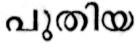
പുതിയ
